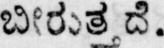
ಬೀರುತ್ತದೆ.
